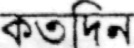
কতদিন
